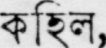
কহিল,
